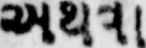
અથવા
